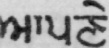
ਆਪਣੇ
